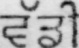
ਵੱਡੀ
